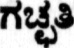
ಗಚ್ಛತಿ
